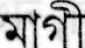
মাগী
